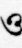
ও
